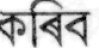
কৰিব
